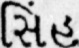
સિંહ
